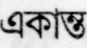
একান্ত
